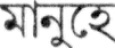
মানুহে
